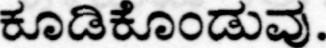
ಕೂಡಿಕೊಂಡುವು.
